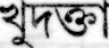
খুদক্তা
